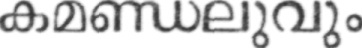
കമണ്ഡലുവും
